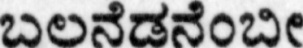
ಬಲನೆಡನೆಂಬೀ
